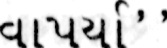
વાપર્યા"
